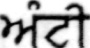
ਅੰਟੀ
